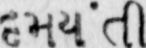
દમયંતી
